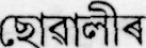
ছোৱালীৰ
